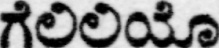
ಗೆಲಿಲಿಯೊ
